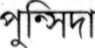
পুন্সিদা
